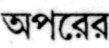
অপরের
